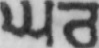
ਘਰ
